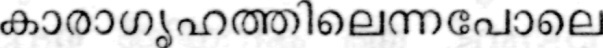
കാരാഗൃഹത്തിലെന്നപോലെ
